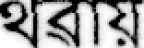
থৱায়
